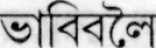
ভাবিবলৈ
